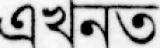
এখনত
